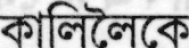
কালিলৈকে
